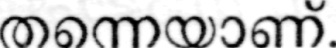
തന്നെയാണ്.
